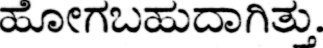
ಹೋಗಬಹುದಾಗಿತ್ತು.
